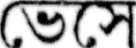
ভেসে
